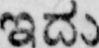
ಇದು
